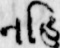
નહિ
